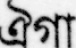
ঐগা
